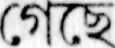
গেছে
